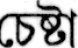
চেষ্টা
